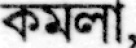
কমলা,
